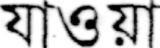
যাওয়া
